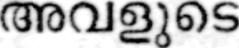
അവളുടെ
